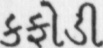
કફોડી
